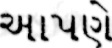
આપણે
